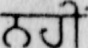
ਨਹੀਂ
